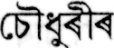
চৌধুৰীৰ
